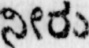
ನೀರು
